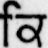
ਕਿ
